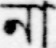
না
